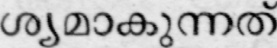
ശ്യമാകുന്നത്
